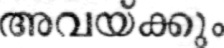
അവയ്ക്കും
